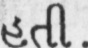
હતી.
